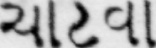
ચાટવા
